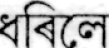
ধৰিলে
